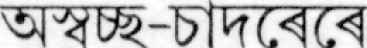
অস্বচ্ছ-চাদৰেৰে
